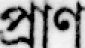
প্রাণ
